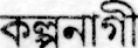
কল্পনাগী
